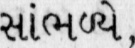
સાંભળ્યે,
